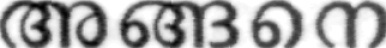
അങ്ങനെ
